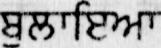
ਬੁਲਾਇਆ
